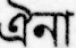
ঐনা
